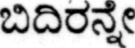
ಬಿದಿರನ್ನೇ
